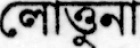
লোত্তুনা
